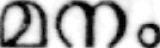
മനം
